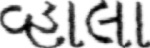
વ્હાલા
